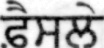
ਫ਼ੈਸਲੇ
